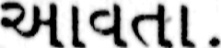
આવતા.
